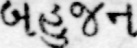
બહુજન
